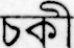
চকী
